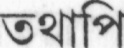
তথাপি
